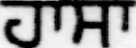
ਹਾਸਾ
